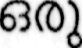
ഒരു
